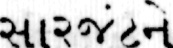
સારજંટને
